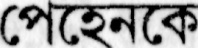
পেহেনকে
